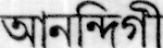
আনন্দিগী
